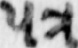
પત્ર
